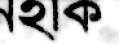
নহাক
